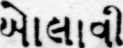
બોલાવી
